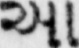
આ
